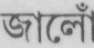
জালোঁ
